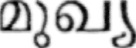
മുഖ്യ
